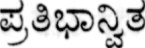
ಪ್ರತಿಭಾನ್ವಿತ
